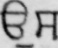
ਉਸ
